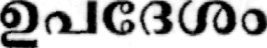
ഉപദേശം
